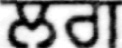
ਲਗ
